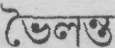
ভৈলন্ত
